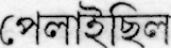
পেলাইছিল
